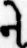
ને
